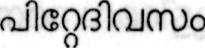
പിറ്റേദിവസം
